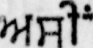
ਅਸੀਂ
